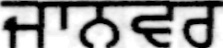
ਜਾਨਵਰ
